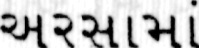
અરસામાં
